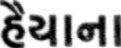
હૈયાના
